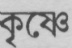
কৃষ্ণে
